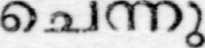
ചെന്നു
